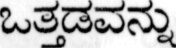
ಒತ್ತಡವನ್ನು
